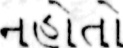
નહોતો
